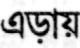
এড়ায়
